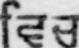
ਵਿਚ
